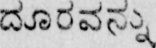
ದೂರವನ್ನು
